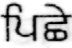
ਪਿਛੇ
